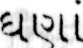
ઘણાં
